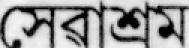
সেৱাশ্রম
